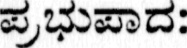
ಪ್ರಭುಪಾದ:
